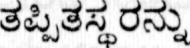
ತಪ್ಪಿತಸ್ಥರನ್ನು
